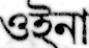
ওইনা
